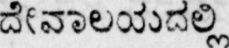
ದೇವಾಲಯದಲ್ಲಿ
